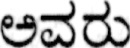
ಅವರು
